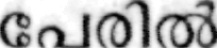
പേരില്‍
